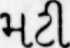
મટી
